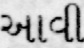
આવી
